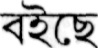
বইছে
